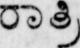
ರಾತ್ರಿ
